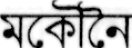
মকৌনৈ
